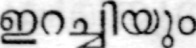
ഇറച്ചിയും
